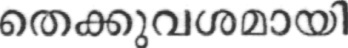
തെക്കുവശമായി
